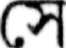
সে
